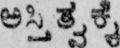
ಅಸ್ತಿತ್ವಕ್ಕೆ
